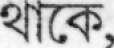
থাকে,
